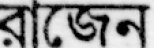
রাজেন
